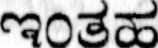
ಇಂತಹ
